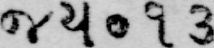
જય.
